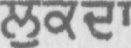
ਲੁਕਦਾ
